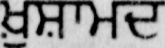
ਖ਼ੁਸ਼ਾਮਦ
